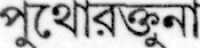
পুথোরক্তুনা
